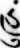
હું
